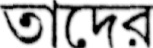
তাদের
